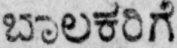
ಬಾಲಕರಿಗೆ
